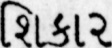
શિકાર
